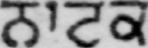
ਨਾਟਕ
